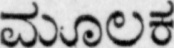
ಮೂಲಕ
